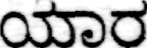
ಯಾರ
